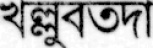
খল্লুবতদা
